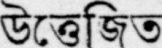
উত্তেজিত
